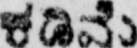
ಕಡಿಮೆ
